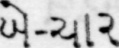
બે-ચાર
